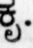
ಕೃ.
